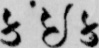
કંઈક
